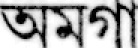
অমগা
